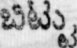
ಬಿಟ್ಟು
